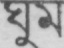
ঘুম
